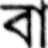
বা
